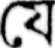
যে
